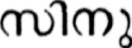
സിനു
